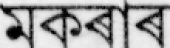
মকৰাৰ
